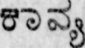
ಕಾವ್ಯ
